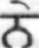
ਨੇ
